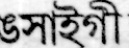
ঙসাইগী
